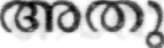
അതു
